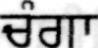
ਚੰਗਾ
